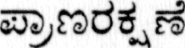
ಪ್ರಾಣರಕ್ಷಣೆ
